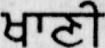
ਖਾਣੀ
